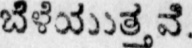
ಬೆಳೆಯುತ್ತವೆ.
